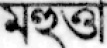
মহুত্তা
